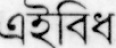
এইবিধ
